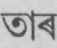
তাৰ
